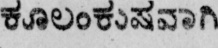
ಕೂಲಂಕುಷವಾಗಿ
